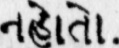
નહોતો.
